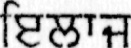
ਇਲਾਜ
